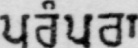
ਪਰੰਪਰਾ
